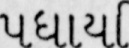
પધાર્યા
